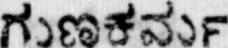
ಗುಣಕರ್ಮ
